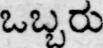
ಒಬ್ಬರು
